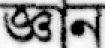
জ্ঞান
